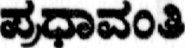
ಪ್ರಧಾವಂತಿ
